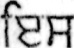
ਇਸ
